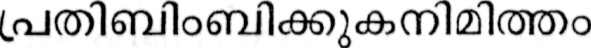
പ്രതിബിംബിക്കുകനിമിത്തം
